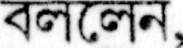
বললেন,
